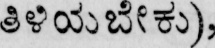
ತಿಳಿಯಬೇಕು),
